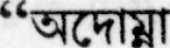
“অদোম্না
